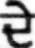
ਦੇ
